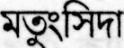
মতুংসিদা
